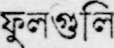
ফুলগুলি
